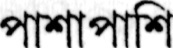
পাশাপাশি
